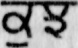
ਕੁਝ
